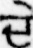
ਦੇ
